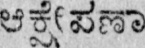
ಆಕ್ಷೇಪಣಾ
